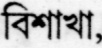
বিশাখা,
